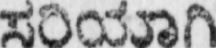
ಸರಿಯಾಗಿ
